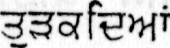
ਤੁੜਕਦਿਆਂ
